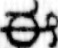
ಈ
